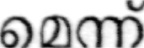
മെന്ന്
